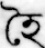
হৈ
